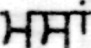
ਮਸਾਂ
